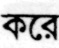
করে
